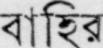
বাহির
